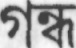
গন্ধ
